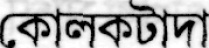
কোলকটাদা
